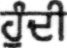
ਹੁੰਦੀ
